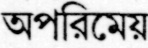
অপরিমেয়
